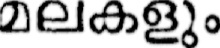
മലകളും
